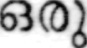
ഒരു
